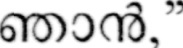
ഞാന്‍,"
